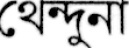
থেন্দুনা
